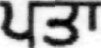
ਪਤਾ
